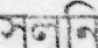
সলনি
